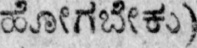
ಹೋಗಬೇಕು)
